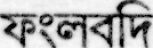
ফংলবদি
